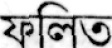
ফলিত
